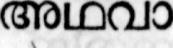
അഥവാ
